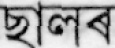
ছালৰ
